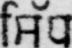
ਸਿੱਧ
